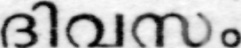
ദിവസം
